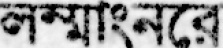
লম্মাংনরে
